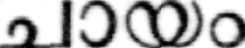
ചായം
